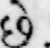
છે.
